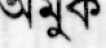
অমুক
